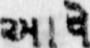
આવે
